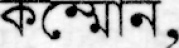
কম্মোন,
